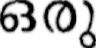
ഒരു
